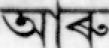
আৰু
